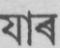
যাৰ
